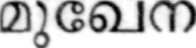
മുഖേന
